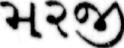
મરજી
